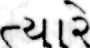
ત્યારે
